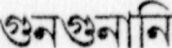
গুনগুনানি
